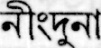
নীংদুনা
